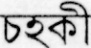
চহকী
